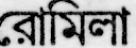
রোমিলা
